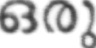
ഒരു
